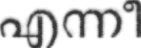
എന്നീ
